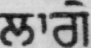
ਲਾਗੇ
